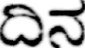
ದಿನ
